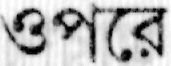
ওপরে
